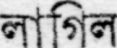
লাগিল
